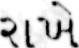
રાખે
